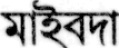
মাইবদা
